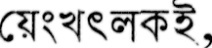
য়েংখৎলকই,
